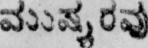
ಮುಷ್ಕರವು
